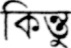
কিন্তু
